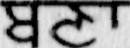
ਬਣਾ
